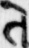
તે
